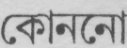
কোননো
